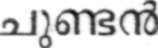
ചുണ്ടന്‍
